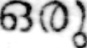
ഒരു
